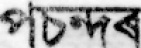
পচন্দৰ
